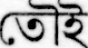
তৌই
